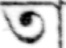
তা
